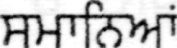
ਸਮਾਨਿਆਂ
